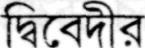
দ্বিবেদীর
